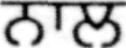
ਨਾਲ
